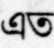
এত
